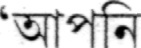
‘আপনি
